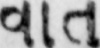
વાત
